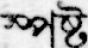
স্পষ্ট
